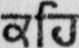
ਕਹਿ
